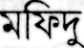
মফিদু
